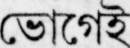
ভোগেই
